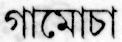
গামোচা
